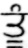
ਤੂੰ
